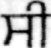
ਸੀ
